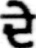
ਦੇ
